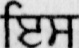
ਇਸ
